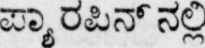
ಪ್ಯಾರಪಿನ್‌ನಲ್ಲಿ
